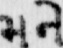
મને
